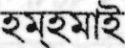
হম্‌হমাই
